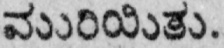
ಮುರಿಯಿತು.
